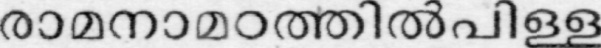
രാമനാമഠത്തില്‍പിള്ള
